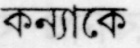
কন্যাকে
